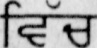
ਵਿੱਚ
